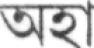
অহা
